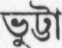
ভুট্টা
